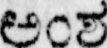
ಅಂಶ
